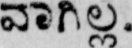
ವಾಗಿಲ್ಲ.
